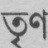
তৃণ
